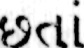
છતાં
